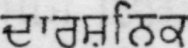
ਦਾਰਸ਼ਨਿਕ
